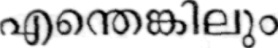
എന്തെങ്കിലും
